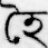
হৈ
